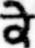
ਕੇ
